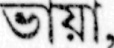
ভায়া,
